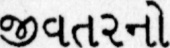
જીવતરનો
